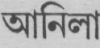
আনিলা
